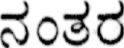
ನಂತರ
